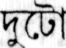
দুটো
